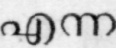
എന്ന
